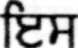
ਇਸ
